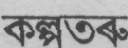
কল্পতৰু
